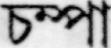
চম্পা
